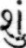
શું
